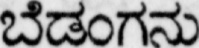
ಬೆಡಂಗನು
